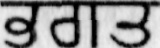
ਭਗਤ
